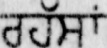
ਰਹੱਸਾਂ
